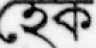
হেক
